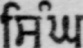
ਸਿੰਘ
